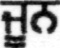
ਜੂਨ
